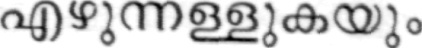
എഴുന്നള്ളുകയും
